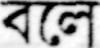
বলে
